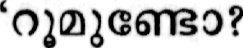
‘റൂമുണ്ടോ?
